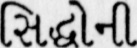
સિદ્ધોની
